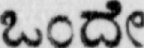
ಒಂದೇ
